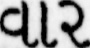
વાર
